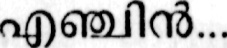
എഞ്ചിന്‍...
